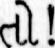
તો!
